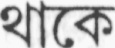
থাকে
